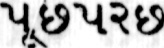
પૂછપરછ
